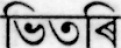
ভিতৰি
